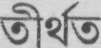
তীৰ্থত
